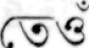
তেওঁ
